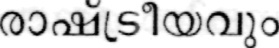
രാഷ്ട്രീയവും
